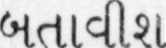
બતાવીશ
